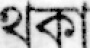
থকা
